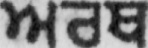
ਅਰਥ
